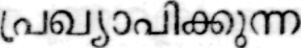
പ്രഖ്യാപിക്കുന്ന
